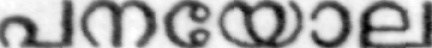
പനയോല
